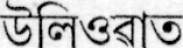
উলিওৱাত
